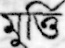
মুর্ত্তি
